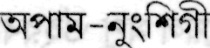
অপাম-নুংশিগী
